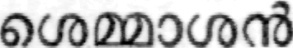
ശെമ്മാശന്‍
